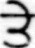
ਤੇ
